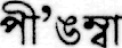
পী’ঙম্বা
